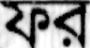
ফর
